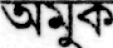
অমুক
